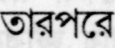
তারপর
